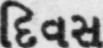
દિવસ
